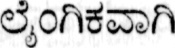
ಲೈಂಗಿಕವಾಗಿ
